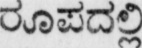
ರೂಪದಲ್ಲಿ
